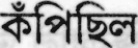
কঁপিছিল
